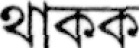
থাকক
